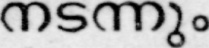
നടന്നും
